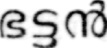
ഭട്ടന്‍
